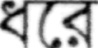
ধরে
